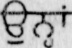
ਉਨ੍ਹਾਂ
